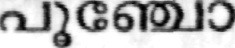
പൂഞ്ചോ
